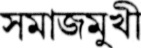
সমাজমুখী
